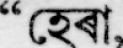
"হেৰা,
